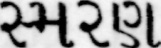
સ્મરણ
